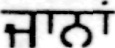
ਜਾਨਾਂ
